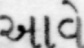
આવે
